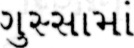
ગુસ્સામાં
